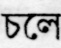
চলে
